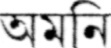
অমনি
